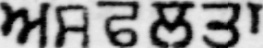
ਅਸਫਲਤਾ
